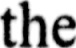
the
